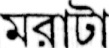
মরাটা
